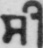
ਸੀ
